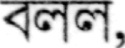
বলল,
